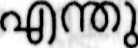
എന്തു
